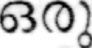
ഒരു
